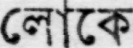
লোকে
